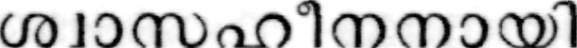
ശ്വാസഹീനനായി
